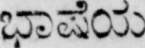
ಭಾಷೆಯ
